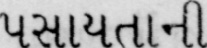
પસાયતાની
